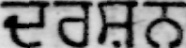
ਦਰਸ਼ਨ
